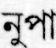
নুপা
